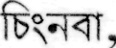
চিংনবা,
